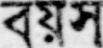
বয়স
